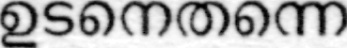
ഉടനെതന്നെ
